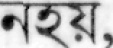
নহয়,
